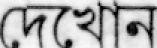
দেখোন
